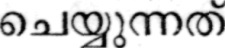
ചെയ്യുന്നത്
